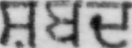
ਸ਼ਬਦ
